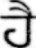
ਹੈ
